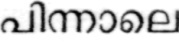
പിന്നാലെ
